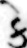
કે
